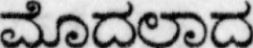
ಮೊದಲಾದ
